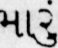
મારું
